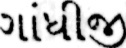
ગાંધીજી
